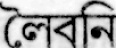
লৈবনি
